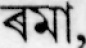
ৰমা,
